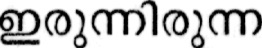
ഇരുന്നിരുന്ന
